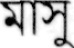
মাসু
